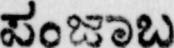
ಪಂಜಾಬ
